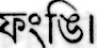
ফংঙি।
